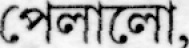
পেলালো,
